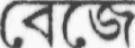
বেজে
